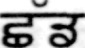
ਛੱਡ
